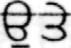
ਉਤੇ
